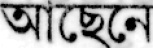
আছেনে
